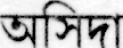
অসিদা
